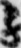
કે
